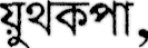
য়ুথকপা,
